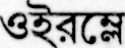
ওইরম্লে
